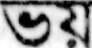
ভয়
